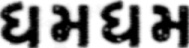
ધમધમ
